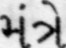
મંત્રે
